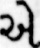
એ
